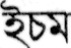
ইচম
